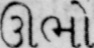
ઊભો
